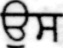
ਉਸ
